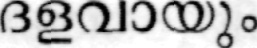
ദളവായും
